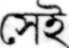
সেই
